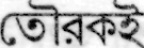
তৌরকই
